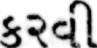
કરવી
